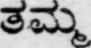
ತಮ್ಮ
